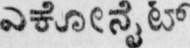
ಎಕೋನೈಟ್
